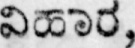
ವಿಹಾರ,
